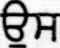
ਉਸ
